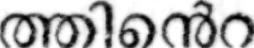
ത്തിന്റെ
